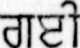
ਗਈ
